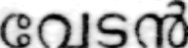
വേടന്‍
